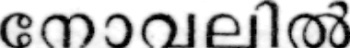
നോവലില്‍
